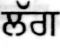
ਲੱਗ
